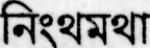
নিংথমথা
